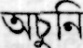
অচুনি
